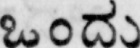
ಒಂದು
